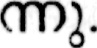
ന്നു.
